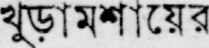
খুড়ামশায়ের
